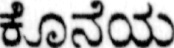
ಕೊನೆಯ
